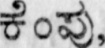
ಕೆಂಪು,
